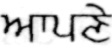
ਆਪਣੇ
